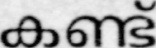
കണ്ട്
